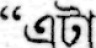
"এটা
